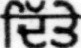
ਦਿੱਤੇ
